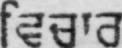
ਵਿਚਾਰ
